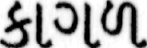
કાગળ
